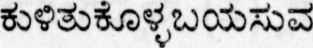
ಕುಳಿತುಕೊಳ್ಳಬಯಸುವ
